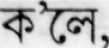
ক'লে,
